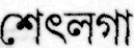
শেৎলগা
